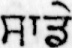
ਸਾਡੇ
